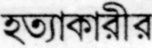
হত্যাকারীর
